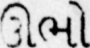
ઊભો
